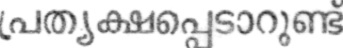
പ്രത്യക്ഷപ്പെടാറുണ്ട്
